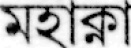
মহাক্না
